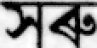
সৰু
